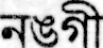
নঙগী
